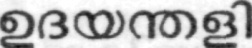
ഉദയന്തളി
